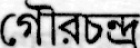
গৌরচন্দ্র
